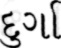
દુર્ગા
